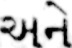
અને
